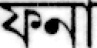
ফনা
